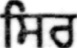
ਸਿਰ
